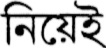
নিয়েই
